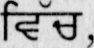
ਵਿੱਚ,
